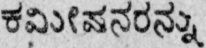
ಕಮೀಷನರನ್ನು
